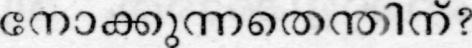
നോക്കുന്നതെന്തിന്?
